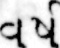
વર્ષ
